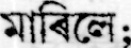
মাৰিলে;
